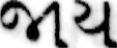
જાય
